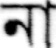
না
